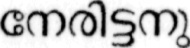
നേരിട്ടനു
